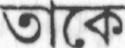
তাকে
